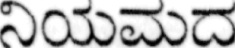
ನಿಯಮದ
